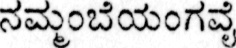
ನಮ್ಮಂಬೆಯಂಗವೈ
